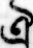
ঐ
